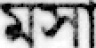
মসা
